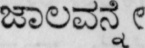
ಜಾಲವನ್ನೇ
